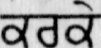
ਕਰਕੇ
